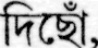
দিছোঁ,
